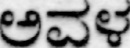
ಅವಳ
